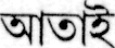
আতাই
